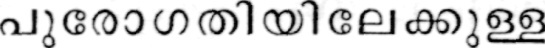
പുരോഗതിയിലേക്കുള്ള
